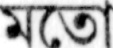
মতো
